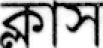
ক্লাস
